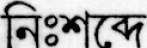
নিঃশব্দে
